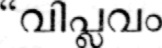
“വിപ്ലവം
